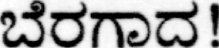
ಬೆರಗಾದ!
